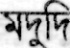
মদুদি
